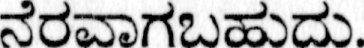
ನೆರವಾಗಬಹುದು.
